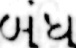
બંધ
